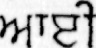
ਆਈ
